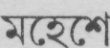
মহেশে
